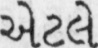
એટલે
